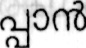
പ്പാന്‍
